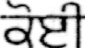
ਕੋਈ
